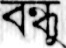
বন্ধু
